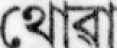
থোৱা
